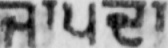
ਜਾਪਦਾ
